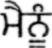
ਮੈਨੂੰ
